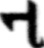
ન
